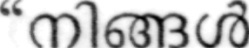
“നിങ്ങള്‍
